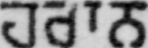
ਹਰਾਨ
